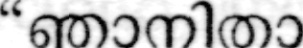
“ഞാനിതാ
